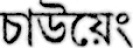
চাউয়েং
